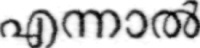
എന്നാല്‍
